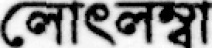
লোৎলম্বা
